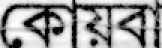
কোয়বা
